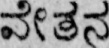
ವೇತನ
